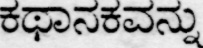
ಕಥಾನಕವನ್ನು
